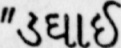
"ડઘાઈ
